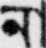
না
